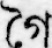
গৈ
